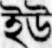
ইউ
